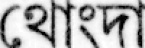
থোংদা
